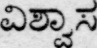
ವಿಶ್ವಾಸ
